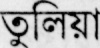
তুলিয়া
